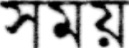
সময়
